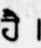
ਹੈ।
